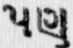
પણ
